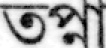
তপ্না
